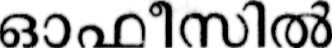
ഓഫീസില്‍
